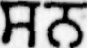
ਸਨ
